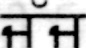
ਜੱਜ
